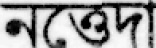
নত্তেদা
